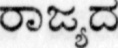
ರಾಜ್ಯದ
